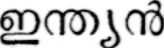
ഇന്ത്യന്‍
